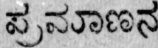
ಪ್ರಮಾಣನ
